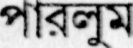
পারলুম
